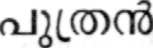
പുത്രന്‍
